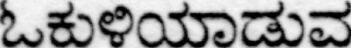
ಓಕುಳಿಯಾಡುವ
